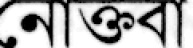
নোক্তবা
